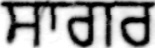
ਸਾਗਰ
